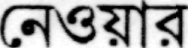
নেওয়ার
